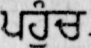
ਪਹੁੰਚ
